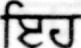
ਇਹ
